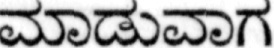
ಮಾಡುವಾಗ
